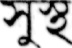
সুস্থ
